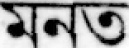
মনত
